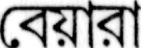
বেয়ারা
